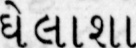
ઘેલાશા
